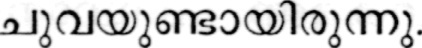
ചുവയുണ്ടായിരുന്നു.
